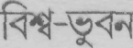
বিশ্ব-ভুবন
